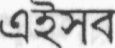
এইসব
